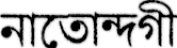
নাতোন্দগী
